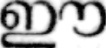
ഈ
